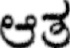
ಆತ
